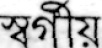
স্বৰ্গীয়
